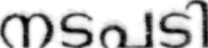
നടപടി
